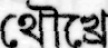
থৌখ্রে
